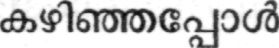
കഴിഞ്ഞപ്പോള്‍
